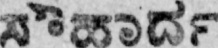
ಸೌಹಾರ್ದ
